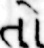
તો
